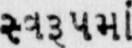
સ્વરૂપમાં
